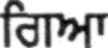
ਗਿਆ
